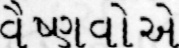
વૈષ્ણવોએ
